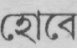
হোবে
